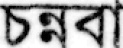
চন্নবা
